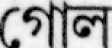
গোল
